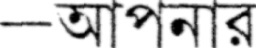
–আপনার
